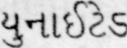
યુનાઈટેડ
